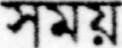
সময়
